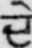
ਦੇ
